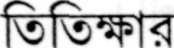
তিতিক্ষার
